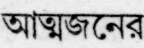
আত্মজনের
